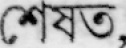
শেষত,
